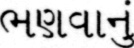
ભણવાનું
